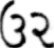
ઉર
